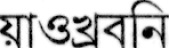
য়াওখ্রবনি
